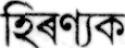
হিৰণ্যক
